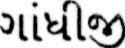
ગાંધીજી
